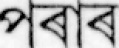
পৰাৰ
